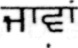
ਜਾਵਾਂ
